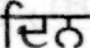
ਦਿਨ
